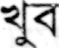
খুব
